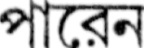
পারেন
